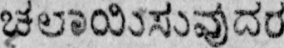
ಚಲಾಯಿಸುವುದರ
